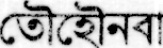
তৌহৌনবা
